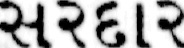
સરદાર
